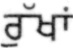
ਰੁੱਖਾਂ
